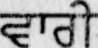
ਵਾਰੀ
